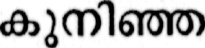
കുനിഞ്ഞ
